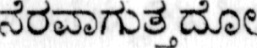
ನೆರವಾಗುತ್ತದೋ
